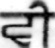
ਵੀ
